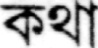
কথা
